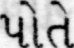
પોતે
